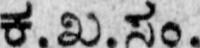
ಕ.ಖ.ಸಂ.
